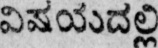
ವಿಷಯದಲ್ಲಿ
